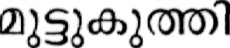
മുട്ടുകുത്തി
